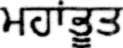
ਮਹਾਂਭੂਤ
